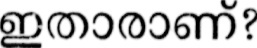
ഇതാരാണ്?
